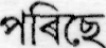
পৰিছে
